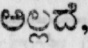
ಅಲ್ಲದೆ,
